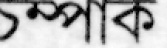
চম্পাক
